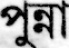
পুন্না
